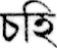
চহি
